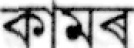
কামৰ
